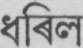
ধৰিল
